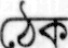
ঠেক
